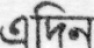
এদিন
